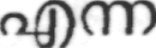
എന്ന
